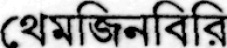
থেমজিনবিরি
